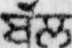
ਬੱਲ
